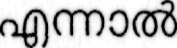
എന്നാല്‍
